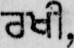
ਰਖੀ,
